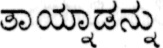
ತಾಯ್ನಾಡನ್ನು
